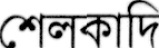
শেলকাদি
